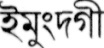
ইমুংদগী
